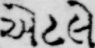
એટલે
